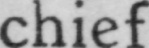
chief
